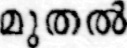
മുതല്‍
